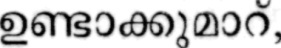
ഉണ്ടാക്കുമാറ്,
